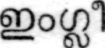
ഇംഗ്ലീ
